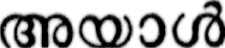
അയാള്‍
